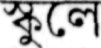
স্কুলে
